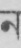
ন
